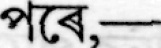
পৰে,-
